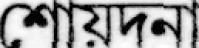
শোয়দনা
